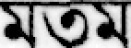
মতম
